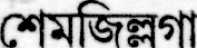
শেমজিল্লগা
